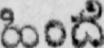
ಹಿಂದೆ
